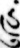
હું
